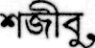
শজীবু,
